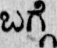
ಬಗ್ಗೆ
